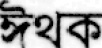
ঈথক
